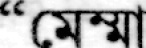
“মেম্মা
